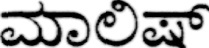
ಮಾಲಿಷ್
